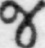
જ
